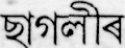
ছাগলীৰ
